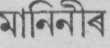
মানিনীৰ
